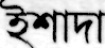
ইশাদা
